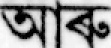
আৰু
